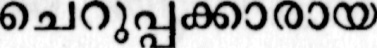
ചെറുപ്പക്കാരായ
